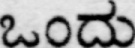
ಒಂದು
